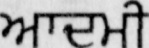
ਆਦਮੀ
